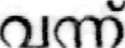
വന്ന്
